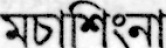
মচাশিংনা
